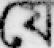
যে
